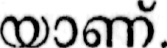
യാണ്.
